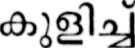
കുളിച്ച്
